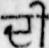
ਦੀ
